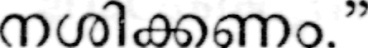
നശിക്കണം."
